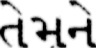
તેમને
